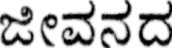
ಜೀವನದ
